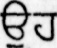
ਉਹ
